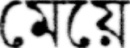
মেয়ে
